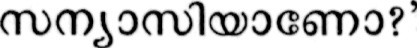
സന്യാസിയാണോ?’
